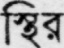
স্থির
